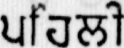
ਪਹਿਲੀ
